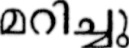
മറിച്ചു
